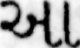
આ
